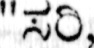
“ಸರಿ,
